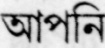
আপনি
